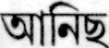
আনিছ
